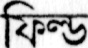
ফিল্ড
